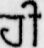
ਹੀ
